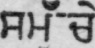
ਸਮੁੱਚੇ
